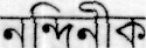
নন্দিনীক
